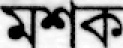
মশক
